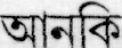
আনকি
